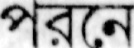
পরনে
